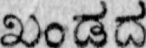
ಖಂಡದ
